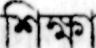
শিক্ষা
